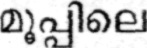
മൂപ്പിലെ
